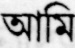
আমি
